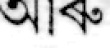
আৰু
